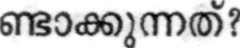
ണ്ടാക്കുന്നത്?
